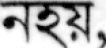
নহয়,
